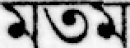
মতম
